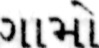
ગામો
